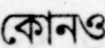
কোনও
